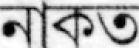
নাকত
